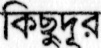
কিছুদূর
